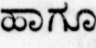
ಹಾಗೂ
